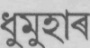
ধুমুহাৰ
